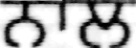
ਨਾਲ
